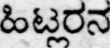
ಹಿಟ್ಲರನ
